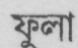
ফুলা
